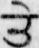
ਤੇ
